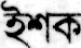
ইশক
